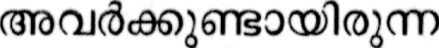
അവര്‍ക്കുണ്ടായിരുന്ന
